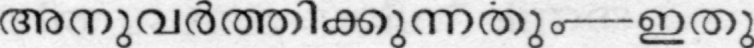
അനുവര്‍ത്തിക്കുന്നതും-ഇതു
